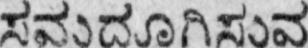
ಸಮದೂಗಿಸುವ
